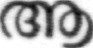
ആ
